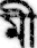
মী
